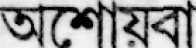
অশোয়বা
